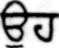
ਉਹ
